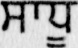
ਸਾਧੂ
